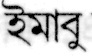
ইমাবু
